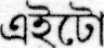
এইটো
